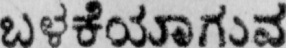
ಬಳಕೆಯಾಗುವ
